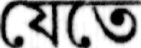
যেতে
